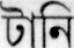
টানি
